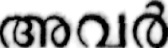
അവര്‍
